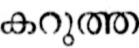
കറുത്ത
